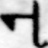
ન
